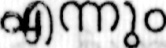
എന്നും
